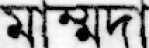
মাম্মদা
